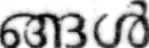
ങ്ങള്‍
